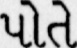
પોતે
